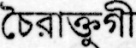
চৈরাক্তুগী
